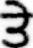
ਤੇ
